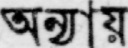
অন্যায়
